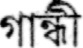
গান্ধী
